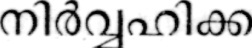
നിര്‍വ്വഹിക്ക
